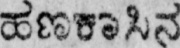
ಹಣಕಾಸಿನ
